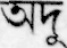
অদু
